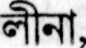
লীনা,
